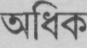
অধিক
